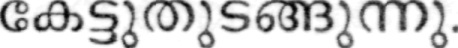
കേട്ടുതുടങ്ങുന്നു.
